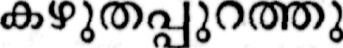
കഴുതപ്പുറത്തു
